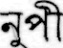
নুপী
